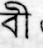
বী
